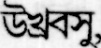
উখ্রবসু,
